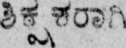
ಶಿಕ್ಷಕರಾಗಿ
